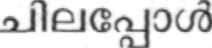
ചിലപ്പോള്‍
